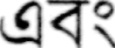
এবং
